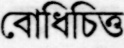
বোধিচিত্ত
